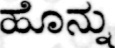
ಹೊನ್ನು
